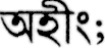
অহীং;
